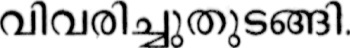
വിവരിച്ചുതുടങ്ങി.
